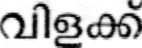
വിളക്ക്
